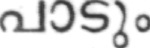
പാടും
